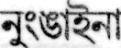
নুংঙাইনা
